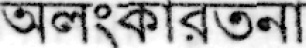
অলংকারতনা
